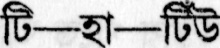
টি–হা–টিঁউ
